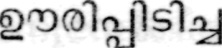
ഊരിപ്പിടിച്ച
